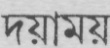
দয়াময়
